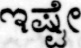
ಇಷ್ಟೇ
